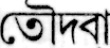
তৌদবা
